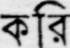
করি
